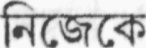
নিজেকে
